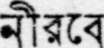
নীরবে
